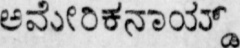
ಅಮೇರಿಕನಾಯ್ಡ್
